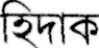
হিদাক
